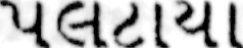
પલટાયા
